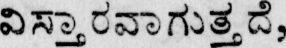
ವಿಸ್ತಾರವಾಗುತ್ತದೆ,
